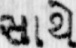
સાથે
